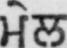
ਮੇਲ
